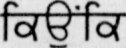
ਕਿਉਂਕਿ
